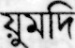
য়ুমদি
